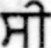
ਸੀ
